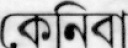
কেনিবা
